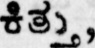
ಕಿತ್ತು,
